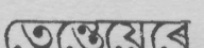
তেন্তেয়েৰে
